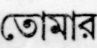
তোমার
